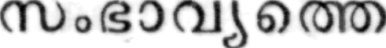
സംഭാവ്യത്തെ
